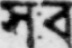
সব
